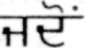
ਜਦੋਂ
